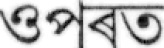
ওপৰত
